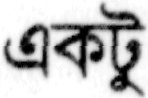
একটু
